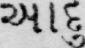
આદુ
